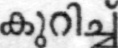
കുറിച്ച്
